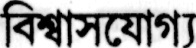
বিশ্বাসযোগ্য
